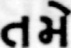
તમે
